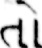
તો
